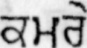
ਕਮਰੇ
